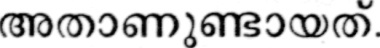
അതാണുണ്ടായത്.
